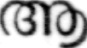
ആ
